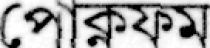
পোক্নফম
